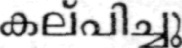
കല്പിച്ചു
